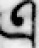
এ
